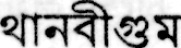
থানবীগুম
